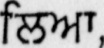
ਲਿਆ,
